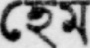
হেম
